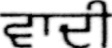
ਵਾਦੀ
